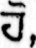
ਹੋ,
